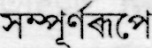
সম্পূর্ণৰূপে
